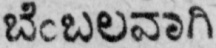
ಬೆಂಬಲವಾಗಿ
